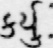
કર્યુ.
